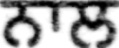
ਨਾਲ
